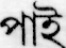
পাই
